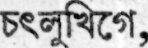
চৎলুখিগে,
